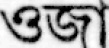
ওজা
